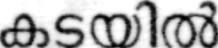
കടയില്‍
